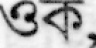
ওক,
